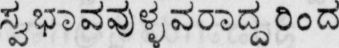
ಸ್ವಭಾವವುಳ್ಳವರಾದ್ದರಿಂದ
